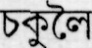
চকুলৈ
